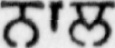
ਨਾਲ
